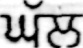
ਘੱਲ
